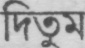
দিতুম
